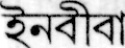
ইনবীবা
